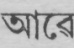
আৱে
